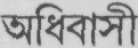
অধিবাসী
